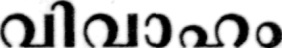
വിവാഹം
